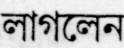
লাগলেন
